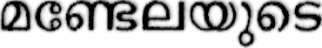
മണ്ടേലയുടെ
